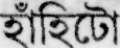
হাঁহিটো
